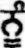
ਨੂੰ
